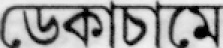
ডেকাচামে
